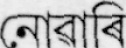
নোৱাৰি
